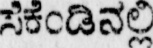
ಸೆಕೆಂಡಿನಲ್ಲಿ
